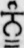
ਨੂੰ
